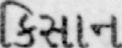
કિસાન
